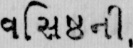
વિસિષ્ઠની,
